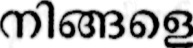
നിങ്ങളെ
